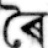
ৰৈ
